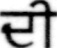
ਦੀ
